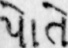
પોતે
